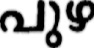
പുഴ
